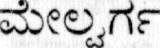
ಮೇಲ್ವರ್ಗ
